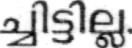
ച്ചിട്ടില്ല.
